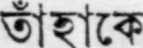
তাঁহাকে
